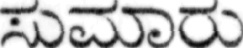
ಸುಮಾರು
